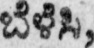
ಬೆಳೆಸಿ,
